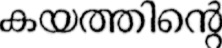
കയത്തിന്റെ
